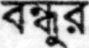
বন্ধুর
